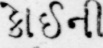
કોઈ
